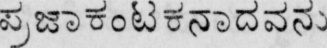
ಪ್ರಜಾಕಂಟಕನಾದವನು
